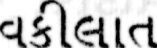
વકીલાત
